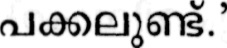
പക്കലുണ്ട്.'
